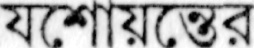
যশোয়ন্তের
